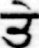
ਤੇ
